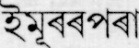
ইমূৰৰপৰা
